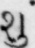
શું
